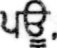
ਪਊ,
